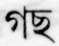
গছ
